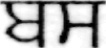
ਬਸ
